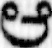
ಆ
